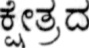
ಕ್ಷೇತ್ರದ
